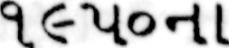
૧૯૫૦ના
